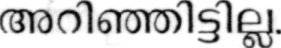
അറിഞ്ഞിട്ടില്ല.
